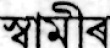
স্বামীৰ
